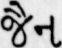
જૈન
